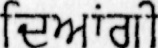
ਦਿਆਂਗੀ
